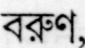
বরুণ,
